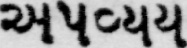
અપવ્યય
